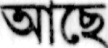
আছে
